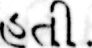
હતી.
